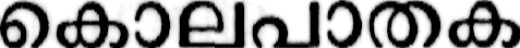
കൊലപാതക
